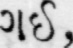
ગઈ,
